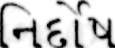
નિર્દોષ
